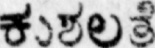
ಕುಶಲತೆ
